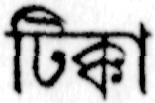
টিক্কা
